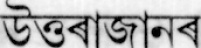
উত্তৰাজানৰ
